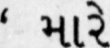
'મારે
